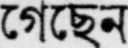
গেছেন
